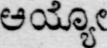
ಅಯ್ಯೋ
